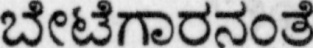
ಬೇಟೆಗಾರನಂತೆ
